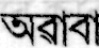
অৱাবা
